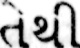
તેથી
